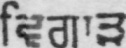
ਵਿਗਾੜ
